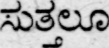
ಸುತ್ತಲೂ
